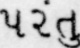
પરંતુ
